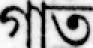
গাত
